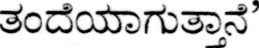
ತಂದೆಯಾಗುತ್ತಾನೆ'
